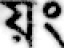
য়ং
